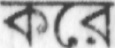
করে
